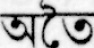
অতৈ
